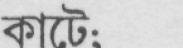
কাটে;
